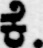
ಕೆ.
